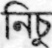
নিচু
